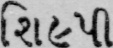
શિલ્પી
